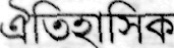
ঐতিহাসিক
